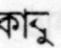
কাবু
